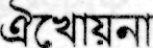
ঐখোয়না
